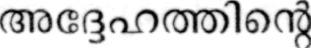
അദ്ദേഹത്തിന്റെ
